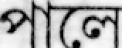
পালে
